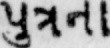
પુત્રના
